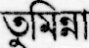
তুমিন্না
